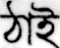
ঠাই
